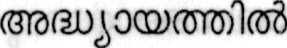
അദ്ധ്യായത്തില്‍
